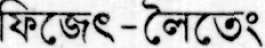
ফিজেৎ-লৈতেং
